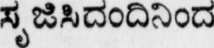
ಸೃಜಿಸಿದಂದಿನಿಂದ
